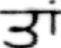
ਤਾਂ
